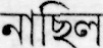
নাছিল
